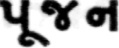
પૂજન
